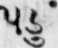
પડું
